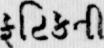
ફટિકની
